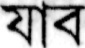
যাব
